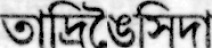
তাদ্রিঙৈসিদা
